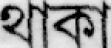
থাকা
